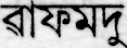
ৱাফমদু
